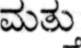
ಮತ್ತು
